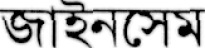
জাইনসেম
